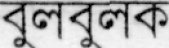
বুলবুলক
